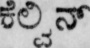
ಕೆಲ್ವಿನ್
